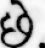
છે.
